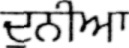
ਦੁਨੀਆ
